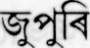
জুপুৰি
